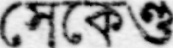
সেকেণ্ড
